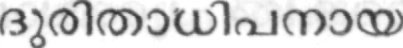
ദുരിതാധിപനായ
